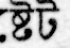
ষ্টেট
